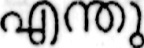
എന്തു
